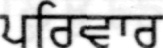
ਪਰਿਵਾਰ
